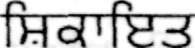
ਸ਼ਿਕਾਇਤ
